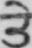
ਤੇ
